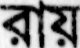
রায়
